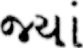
જ્યાં
